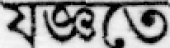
যজ্ঞতে
